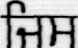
ਜਿਸ
